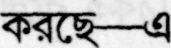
করছে–এ
